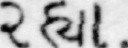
રહ્યા.
